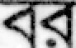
বর
